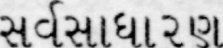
સર્વસાધારણ
